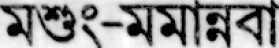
মশুং-মমান্নবা
